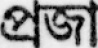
প্রজা
